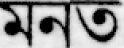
মনত
